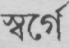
স্বৰ্গে
